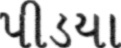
પીડ્યા
